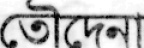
তৌদেনা
